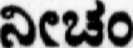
ನೀಚಂ
